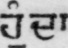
ਹੁੰਦਾ
